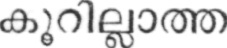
കൂറില്ലാത്ത
